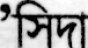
’সিদা
